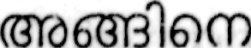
അങ്ങിനെ
